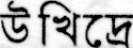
উখিদ্রে
